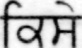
ਕਿਸੇ
